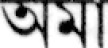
অমা
